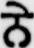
ਨੇ
